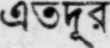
এতদূর
